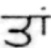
ਤਾਂ
